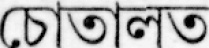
চোতালত
